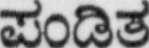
ಪಂಡಿತ
